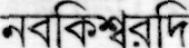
নবকিশ্বরদি
